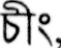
চীং,
